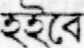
হইবে
